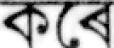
কৰে
